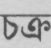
চক্ৰ
